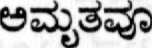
ಅಮೃತವೂ
